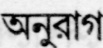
অনুরাগ
